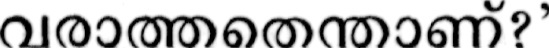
വരാത്തതെന്താണ്?’
